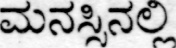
ಮನಸ್ಸಿನಲ್ಲಿ
